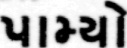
પામ્યો
